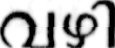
വഴി
